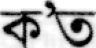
ক'ত
